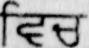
ਵਿਚ
